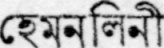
হেমনলিনী
